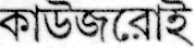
কাউজরোই
